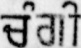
ਚੰਗੀ
